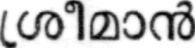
ശ്രീമാന്‍
